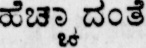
ಹೆಚ್ಚಾದಂತೆ
